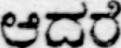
ಆದರೆ
